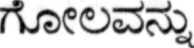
ಗೋಲವನ್ನು
